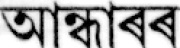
আন্ধাৰৰ
